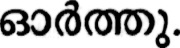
ഓര്‍ത്തു.
